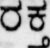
ರಕ್ತ
